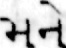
મને
